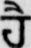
ਹੈ
